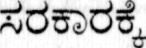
ಸರಕಾರಕ್ಕೆ
